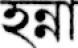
হন্না
